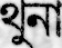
থুনা
